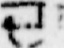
ਦਾ
